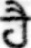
ਹੈ
